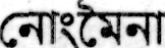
নোংমৈনা
